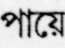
পায়ে
